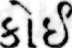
કોઈ
